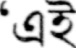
‘এই
